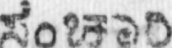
ಸಂಚಾರಿ
